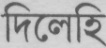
দিলেহি
